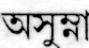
অসুম্না
